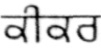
ਕੀਕਰ
